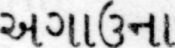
અગાઉના
